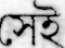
সেই
